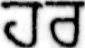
ਹਰ
